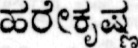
ಹರೇಕೃಷ್ಣ
